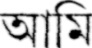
আমি
